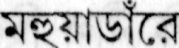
মহুয়াডাঁরে
